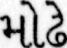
મોઢે
